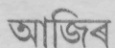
আজিৰ
